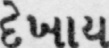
દેખાય
